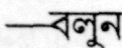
–বলুন
